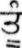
ਤੂੰ
